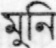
মুনি
